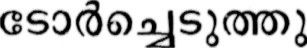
ടോര്‍ച്ചെടുത്തു
